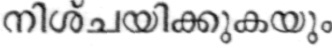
നിശ്ചയിക്കുകയും
